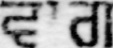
ਵਾਗ
